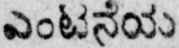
ಎಂಟನೆಯ
